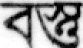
বস্তু
